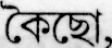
কৈছো,
